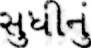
સુધીનું
